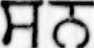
ਸਨ
